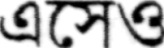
এসেও
